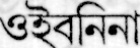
ওইবনিনা
